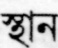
স্থান
